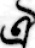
ঐ
